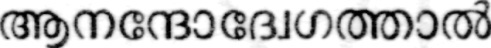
ആനന്ദോദ്വേഗത്താല്‍
